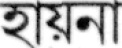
হায়না
